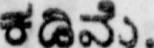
ಕಡಿಮೆ.
